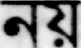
নয়
